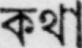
কথা
